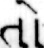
તો
